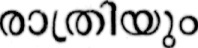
രാത്രിയും
